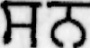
ਸਨ
